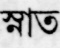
স্নাত
